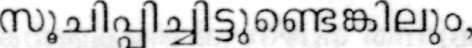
സൂചിപ്പിച്ചിട്ടുണ്ടെങ്കിലും,
